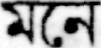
মনে
